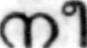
നീ
